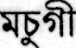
মচুগী
